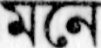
মনে
